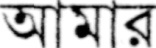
আমার
